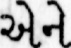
એને
